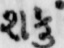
શકું.
